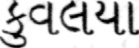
કુવલયા
